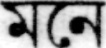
মনে
